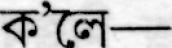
ক'লে-
